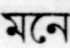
মনে
